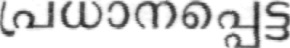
പ്രധാനപ്പെട്ട
